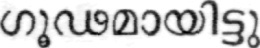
ഗൂഢമായിട്ടു
